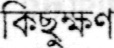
কিছুক্ষণ
